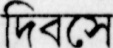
দিবসে
